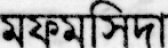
মফমসিদা
